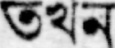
তখন
